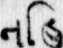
નહિ
